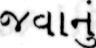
જવાનું
